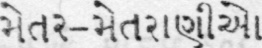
મેતર-મેતરાણીઓ
